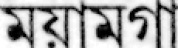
ময়ামগা
